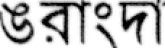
ঙরাংদা
